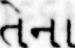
તેના
